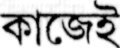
কাজেই
